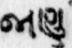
જાણું
